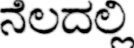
ನೆಲದಲ್ಲಿ
